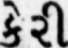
કેરી
